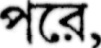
পরে,
